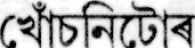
খোঁচনিটোৰ
